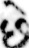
છે
